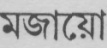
মজায়ো
